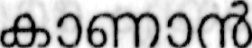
കാണാന്‍
